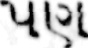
પણ
